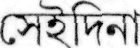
সেইদিনা
